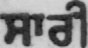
ਸਾਰੀ
